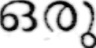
ഒരു
